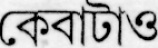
কেবাটাও
